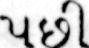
પછી
